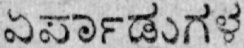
ಏರ್ಪಾಡುಗಳ
